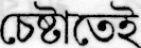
চেষ্টাতেই
